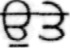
ਉਤੇ
